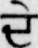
ਦੇ
